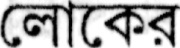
লোকের
